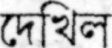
দেখিল
